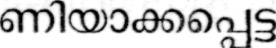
ണിയാക്കപ്പെട്ട
